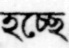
হচ্ছে
